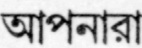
আপনারা
